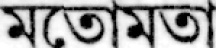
মতোমতা
